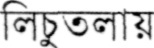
লিচুতলায়
